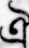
ঐ
